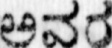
ಅವರ
